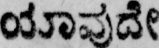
ಯಾವುದೇ
